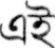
এই
